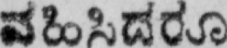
ವಹಿಸಿದರೂ
